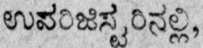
ಉಪರಿಜಿಸ್ಟರಿನಲ್ಲಿ,
